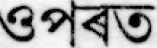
ওপৰত
